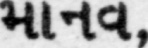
માનવ,
